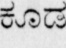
ಕೂಡ
